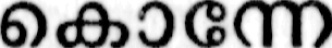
കൊന്നേ
